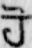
ਹੋ
